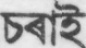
চৰাই
